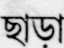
ছাড়া
